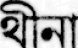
থীনা
